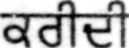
ਕਰੀਦੀ
